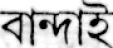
বান্দাই
